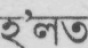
হ'লত
